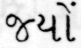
જ્યોં
